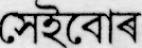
সেইবোৰ
